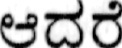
ಆದರೆ
